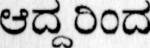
ಆದ್ದರಿಂದ
